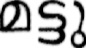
മട്ടു
